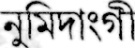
নুমিদাংগী
